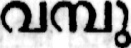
വമ്പു
